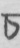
চ
